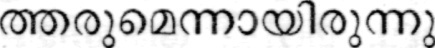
ത്തരുമെന്നായിരുന്നു
